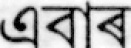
এবাৰ
